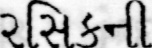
રસિકની
